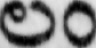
ಲಂ
